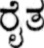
ರೈತ
